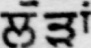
ਲੋੜਾਂ
